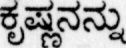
ಕೃಷ್ಣನನ್ನು
